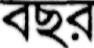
বছর
